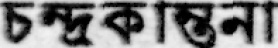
চন্দ্রকান্তনা
